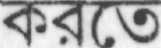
করতে
